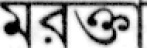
মরক্তা
